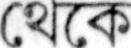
থেকে
